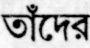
তাঁদের
